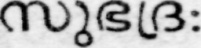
സുഭദ്ര:
